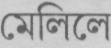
মেলিলে
